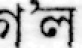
গ'ল
